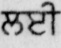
ਲਈ
